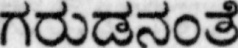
ಗರುಡನಂತೆ
